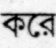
করে
